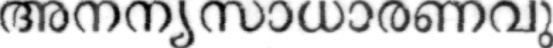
അനന്യസാധാരണവു
